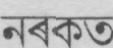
নৰকত
